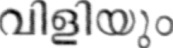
വിളിയും
